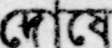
দোষে
